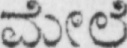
ಮೇಲೆ
